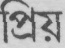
প্ৰিয়
